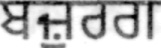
ਬਜ਼ੁਰਗ
